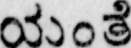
ಯಂತೆ
